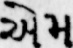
એમ
